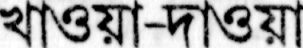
খাওয়া-দাওয়া
